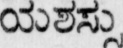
ಯಶಸ್ಸು
